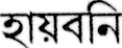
হায়বনি
